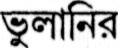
ভুলানির
